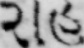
રાહ
